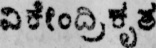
ವಿಕೇಂದ್ರಿಕೃತ
